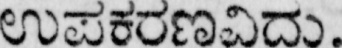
ಉಪಕರಣವಿದು.
